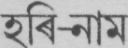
হৰি-নাম
